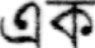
এক
